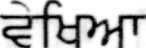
ਵੇਖਿਆ
